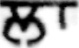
ਲਾ
